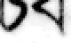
চব
